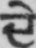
ਦੇ
